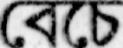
বেচে
